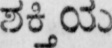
ಶಕ್ತಿಯ
